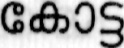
കോട്ട
